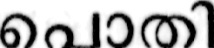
പൊതി
